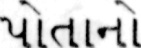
પોતાનો
